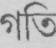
গতি
